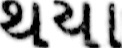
થયા
